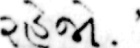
રહેજો.'
